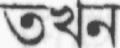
তখন
